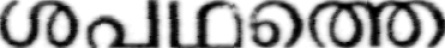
ശപഥത്തെ
